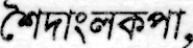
শৈদাংলকপা,
